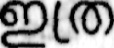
ഇത്ര
